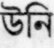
উনি
